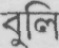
বুলি
